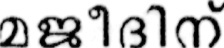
മജീദിന്
